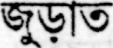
জুড়াত
